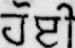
ਹੋਈ
